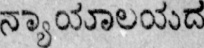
ನ್ಯಾಯಾಲಯದ
